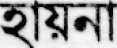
হায়না
